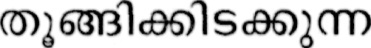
തൂങ്ങിക്കിടക്കുന്ന
